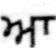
ਆ
